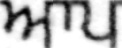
ਆਪ
